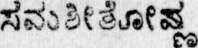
ಸಮಶೀತೋಷ್ಣ
